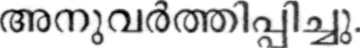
അനുവര്‍ത്തിപ്പിച്ചു.
